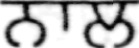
ਨਾਲ
